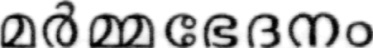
മര്‍മ്മഭേദനം
